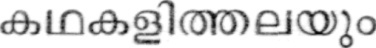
കഥകളിത്തലയും
